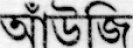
আঁউজি
